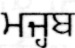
ਮਜ਼੍ਹਬ
